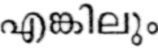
എങ്കിലും
